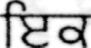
ਇਕ
